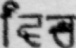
ਵਿਚ
